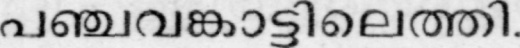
പഞ്ചവങ്കാട്ടിലെത്തി.
